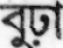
বুঢ়া
